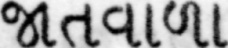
જાતવાળા
